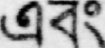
এবং
